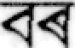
বৰ
